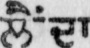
ਲੈਂਦਾ
